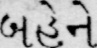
બહેને
